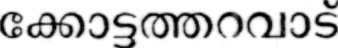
ക്കോട്ടത്തറവാട്
